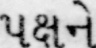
પક્ષને
